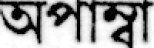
অপাম্বা
